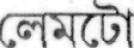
লেমটো
